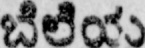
ಬೆಲೆಯ
